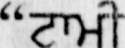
''ਟਾਮੀ
